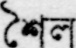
শৈল
